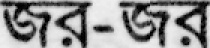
জর-জর
